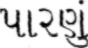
પારણું
